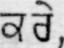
ਕਰੇ,
